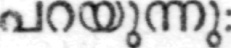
പറയുന്നു:
